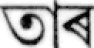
তাৰ
